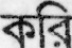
করি
